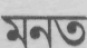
মনত
